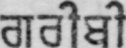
ਗਰੀਬੀ
